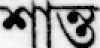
শান্ত
